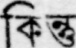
কিন্তু
